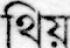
থিয়
